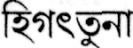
হিগৎতুনা
